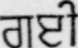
ਗਈ
